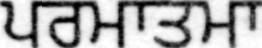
ਪਰਮਾਤਮਾ
